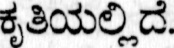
ಕೃತಿಯಲ್ಲಿದೆ.
